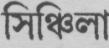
সিঞ্চিলা
